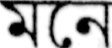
মনে
